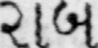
રાબ
